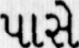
પાસે
